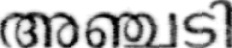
അഞ്ചടി
